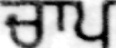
ਚਾਪ
